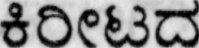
ಕಿರೀಟದ
